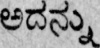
ಅದನ್ನು
